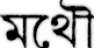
মথৌ
